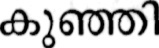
കുഞ്ഞി
